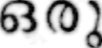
ഒരു
